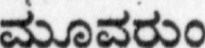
ಮೂವರುಂ
